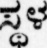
ಸ್ಥಳ
